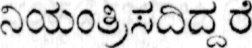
ನಿಯಂತ್ರಿಸದಿದ್ದರೆ
